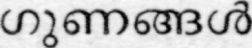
ഗുണങ്ങള്‍
